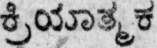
ಕ್ರಿಯಾತ್ಮಕ
